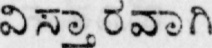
ವಿಸ್ತಾರವಾಗಿ
